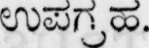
ಉಪಗ್ರಹ.
